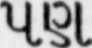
પણ
